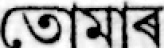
তোমাৰ
